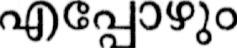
എപ്പോഴും
